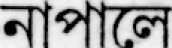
নাপালে
